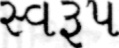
સ્વરૂપ
